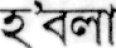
হ'বলা
